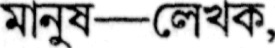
মানুষ-লেখক,
